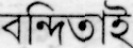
বন্দিতাই
